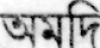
অমদি
